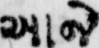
આજે
